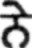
ਨੇ
